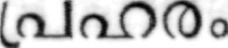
പ്രഹരം
